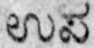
ಉಪ
